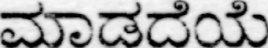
ಮಾಡದೆಯೆ
